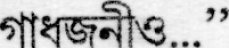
গাধজনীও..."
